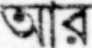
আর
